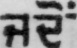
ਜਦੋਂ
